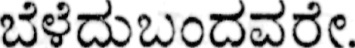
ಬೆಳೆದುಬಂದವರೇ.
